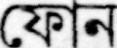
ফোন
